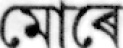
মোৰে
